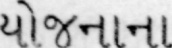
યોજનાના
